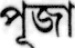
পূজা
